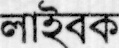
লাইবক
